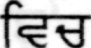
ਵਿਚ
